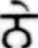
ਨੇ
